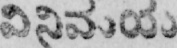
ವಿನಿಮಯ
